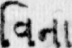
વિના
